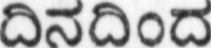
ದಿನದಿಂದ
